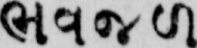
ભવજળ
